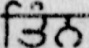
ਤਿੰਨ
